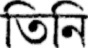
তিনি
